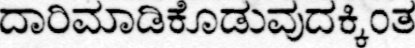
ದಾರಿಮಾಡಿಕೊಡುವುದಕ್ಕಿಂತ
